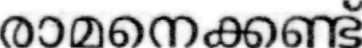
രാമനെക്കണ്ട്
